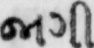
જાગી
